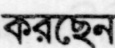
করছেন
